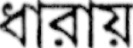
ধারায়
